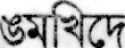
ঙমখিদে
